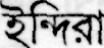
ইন্দিরা
